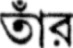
তাঁর
